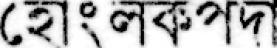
হোংলকপদা
